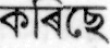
কৰিছে
